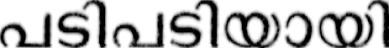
പടിപടിയായി
